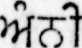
ਅੰਨੀ
